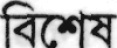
বিশেষ
